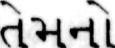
તેમનો
